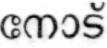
നോട്
